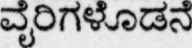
ವೈರಿಗಳೊಡನೆ
